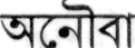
অনৌবা
